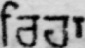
ਰਿਹਾ
